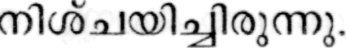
നിശ്ചയിച്ചിരുന്നു.
